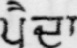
ਪੈਦਾ
